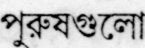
পুরুষগুলো
